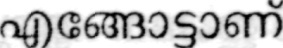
എങ്ങോട്ടാണ്
